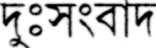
দুঃসংবাদ
